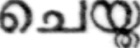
ചെയ്ത
